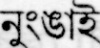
নুংঙাই
